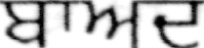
ਬਾਅਦ
